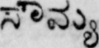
ಸೌಮ್ಯ
